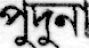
পুদুনা
